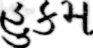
હુકમ
